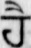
ਹੈ
